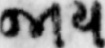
જાય
